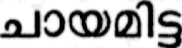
ചായമിട്ട
